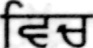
ਵਿਚ
